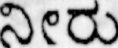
ನೀರು
